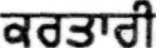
ਕਰਤਾਰੀ
